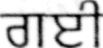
ਗਈ
